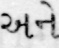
અને
